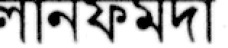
লানফমদা
